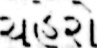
ચહેરો
